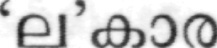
'ല'കാര
